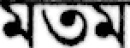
মতম
